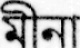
মীনা
